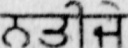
ਨਤੀਜੇ
